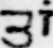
ਤਾਂ
